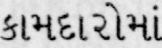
કામદારોમાં
